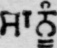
ਸਾਨੂੰ
